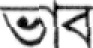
ভাব
